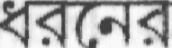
ধরনের
